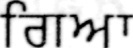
ਗਿਆ
